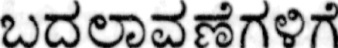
ಬದಲಾವಣೆಗಳಿಗೆ
